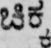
ಚಿಕ್ಕ
